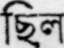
ছিল
